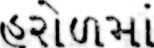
હરોળમાં
